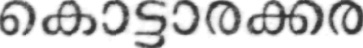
കൊട്ടാരക്കര
